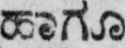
ಹಾಗೂ
